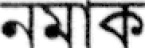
নমাক
